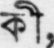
কী,
